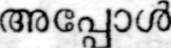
അപ്പോള്‍
